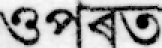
ওপৰত
